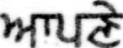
ਆਪਣੇ
